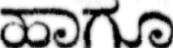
ಹಾಗೂ
